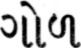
ગોળ
